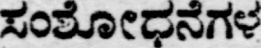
ಸಂಶೋಧನೆಗಳ
